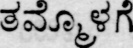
ತಮ್ಮೊಳಗೆ
